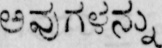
ಅವುಗಳನ್ನು
